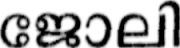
ജോലി
